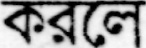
করলে
